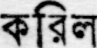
করিল
